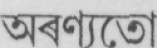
অৰণ্যতো
